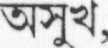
অসুখ,
